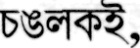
চঙলকই,
